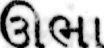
ઊભા
